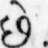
છે.
